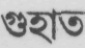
গুহাত
